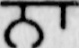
ਨਾ
